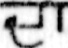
ਦਾ
